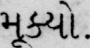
મૂક્યો.
